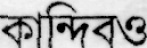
কান্দিবও
